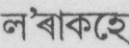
ল'ৰাকহে
